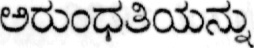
ಅರುಂಧತಿಯನ್ನು
